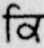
ਕਿ
